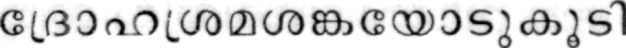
ദ്രോഹശ്രമശങ്കയോടുകൂടി
